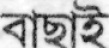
বাছাই
